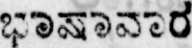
ಭಾಷಾವಾರ
